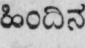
ಹಿಂದಿನ
